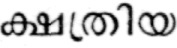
ക്ഷത്രിയ
